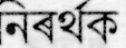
নিৰর্থক
